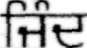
ਜਿੰਦ
